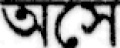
অসে
